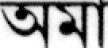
অমা
